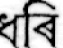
ধৰি
